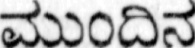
ಮುಂದಿನ
